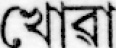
খোৱা
